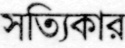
সত্যিকার
